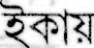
ইকায়
